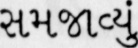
સમજાવ્યું
